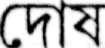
দোষ
